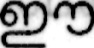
ഈ
